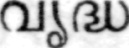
വൃദ്ധ
